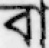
বা
